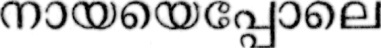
നായയെപ്പോലെ
